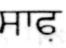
ਸਾਫ਼
